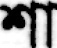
শা
